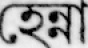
হেন্না
